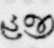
હજી
